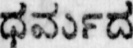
ಧರ್ಮದ
